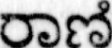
ರಾಣಿ
